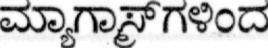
ಮ್ಯಾಗ್ಮಾಸ್‌ಗಳಿಂದ
